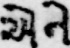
એને
